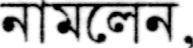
নামলেন,
